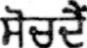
ਸੋਚਦੈਂ
